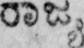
ರಾಜ್ಯ
